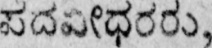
ಪದವೀಧರರು,
